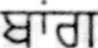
ਬਾਂਗ
